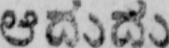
ಆದುದು
